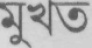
মুখত
